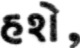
હશે,
